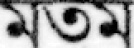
মতম
